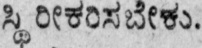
ಸ್ಥಿರೀಕರಿಸಬೇಕು.
